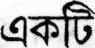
একটি
